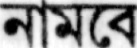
নামবে
